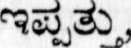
ಇಪ್ಪತ್ತು,
